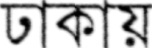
ঢাকায়
